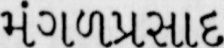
મંગળપ્રસાદ
